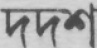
দদশ
